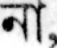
না,
